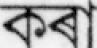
কৰা
